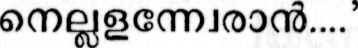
നെല്ലളന്ന്വേരാന്‍....'
